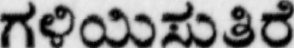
ಗಳಿಯಿಸುತಿರೆ
